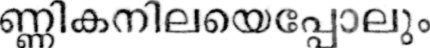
ണ്ണികനിലയെപ്പോലും
